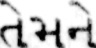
તેમને
